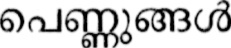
പെണ്ണുങ്ങള്‍
